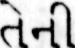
તેની
